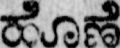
ಹೊಣೆ
